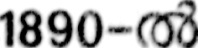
1890-ല്‍
